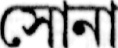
সোনা
